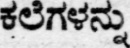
ಕಲೆಗಳನ್ನು
